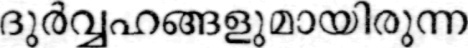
ദുര്‍വ്വഹങ്ങളുമായിരുന്ന
